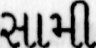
સામી
